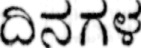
ದಿನಗಳ
